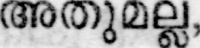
അതുമല്ല,
